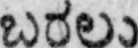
ಬರಲು
